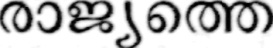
രാജ്യത്തെ
